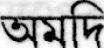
অমদি
